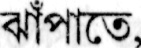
ঝাঁপাতে,
